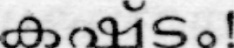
കഷ്ടം!
